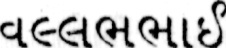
વલ્લભભાઈ
